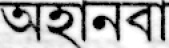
অহানবা
